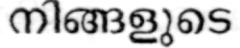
നിങ്ങളുടെ
